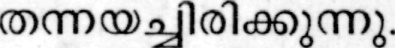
തന്നയച്ചിരിക്കുന്നു.
